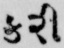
કરી
